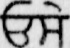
ਓਸੇ
